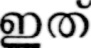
ഇത്
